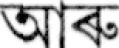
আৰু
